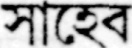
সাহেব
